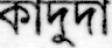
কাদুদা
